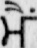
ਮੈਂ
